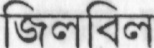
জিলবিল
